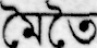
মৈতৈ
